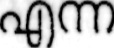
എന്ന
